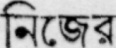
নিজের
